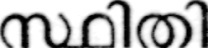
സ്ഥിതി
